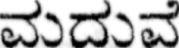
ಮದುವೆ
